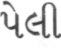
પેલી
